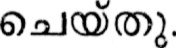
ചെയ്തു.
